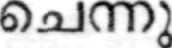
ചെന്നു
